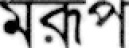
মরূপ
